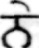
ਨੇ
